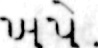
ખપે.
